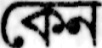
কেন
